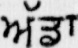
ਅੱਡਾ
